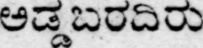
ಅಡ್ಡಬರದಿರು
